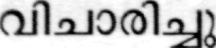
വിചാരിച്ചു
